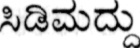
ಸಿಡಿಮದ್ದು
